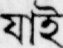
যাই
